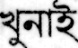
খুনাই
